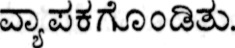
ವ್ಯಾಪಕಗೊಂಡಿತು.
